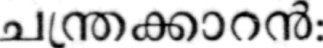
ചന്ത്രക്കാറന്‍:
